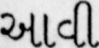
આવી
